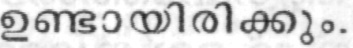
ഉണ്ടായിരിക്കും.
